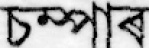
চম্পাৰ
